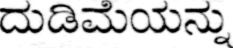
ದುಡಿಮೆಯನ್ನು
